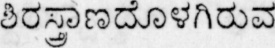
ಶಿರಸ್ತ್ರಾಣದೊಳಗಿರುವ
